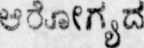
ಆರೋಗ್ಯದ
